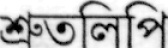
শ্রুতলিপি
